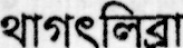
থাগৎলিব্রা
